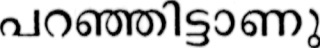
പറഞ്ഞിട്ടാണു
